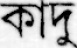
কাদু
